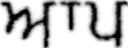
ਆਪ
